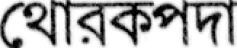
থোরকপদা
